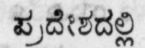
ಪ್ರದೇಶದಲ್ಲಿ
